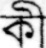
কী
